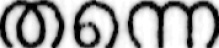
തന്നെ
